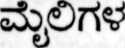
ಮೈಲಿಗಳ
